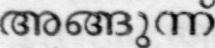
അങ്ങുന്ന്
